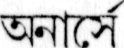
অনার্সে
